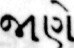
જાણે
